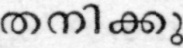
തനിക്കു
